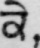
ਕੇ,
